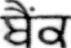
ਬੈਂਕ
